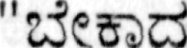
“ಬೇಕಾದ
